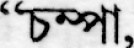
"চম্পা,
